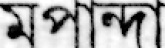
মপান্দা
